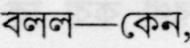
বলল–কেন,
